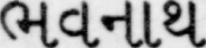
ભવનાથ
